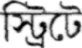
স্ট্রিটে
